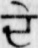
ਦੇ
